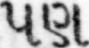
પણ
